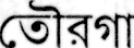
তৌরগা
